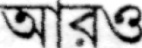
আরও
